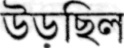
উড়ছিল
